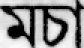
মচা
